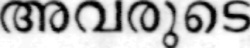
അവരുടെ
